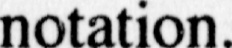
notation.
